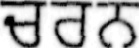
ਚਰਨ
